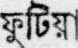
ফুটিয়া
